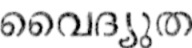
വൈദ്യുത
